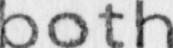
both
